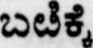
ಬೞಕ್ಕೆ
